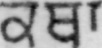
ਕਥਾ
